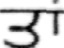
ਤਾਂ
